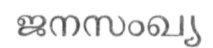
ജനസംഖ്യ
